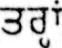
ਤਰ੍ਹਾਂ
